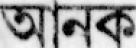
আনক
